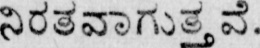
ನಿರತವಾಗುತ್ತವೆ.
